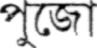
পুজো
